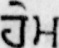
ਹੇਮ
